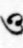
ও
